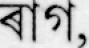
ৰাগ,
